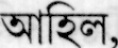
আহিল,
